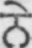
ਨੇ
